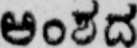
ಅಂಶದ
